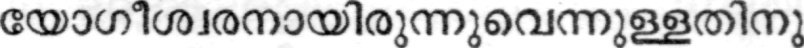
യോഗീശ്വരനായിരുന്നുവെന്നുള്ളതിനു
